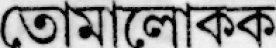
তোমালোকক
